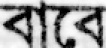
বাবে
